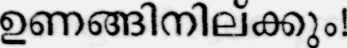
ഉണങ്ങിനില്ക്കും!
